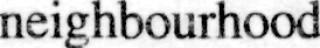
neighbourhood
